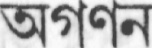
অগণন
